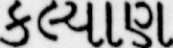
કલ્યાણ
